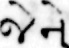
જેને
